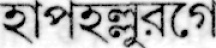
হাপহল্লুরগে
